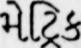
મેટ્રિક
